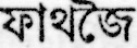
ফাথজৈ
